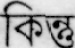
কিন্তু
